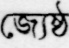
জ্যেষ্ঠ
